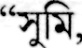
“সুমি,
